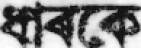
ধাৰকে
